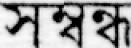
সম্বন্ধ
